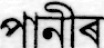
পানীৰ
